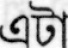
এটা
